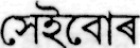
সেইবোৰ
